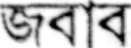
জবাব
